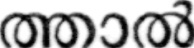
ത്താല്‍
